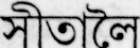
সীতালৈ
